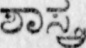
ಶಾಸ್ತ್ರ
